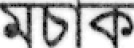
মচাক
